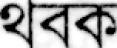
থবক
